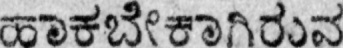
ಹಾಕಬೇಕಾಗಿರುವ
